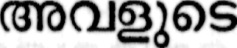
അവളുടെ
